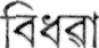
বিধৱা
